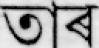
তাৰ
